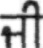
ਜੀ
